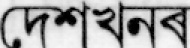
দেশখনৰ
